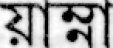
য়াম্না
